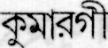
কুমারগী
